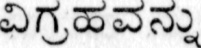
ವಿಗ್ರಹವನ್ನು
